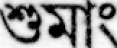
শুমাং
